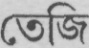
তেজি
